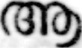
ആ
